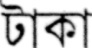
টাকা
